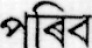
পৰিব
